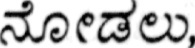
ನೋಡಲು,
